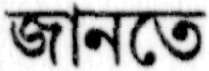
জানতে
